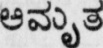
ಅಮೃತ
